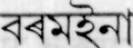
বৰমইনা
